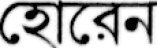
হোরেন
